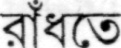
রাঁধতে
